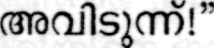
അവിടുന്ന്!”
